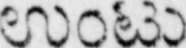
ಉಂಟು
